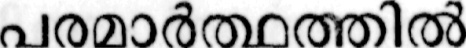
പരമാര്‍ത്ഥത്തില്‍
